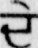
ਦੇ
